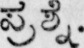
ಪ್ರಶ್ನೆ.
